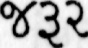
જરૂર
